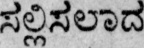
ಸಲ್ಲಿಸಲಾದ
